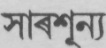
সাৰশূন্য
